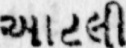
આટલી
